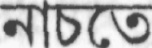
নাচতে
